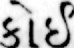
કોઈ
